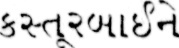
કસ્તૂરબાઈને
